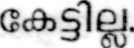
കേട്ടില്ല.
